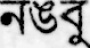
নঙবু
